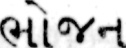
ભોજન
